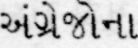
અંગ્રેજોના
